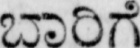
ಬಾರಿಗೆ
